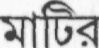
মাটির
